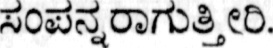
ಸಂಪನ್ನರಾಗುತ್ತೀರಿ.
